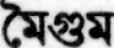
মৈগুম
